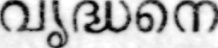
വൃദ്ധനെ
